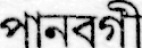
পানবগী
